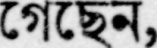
গেছেন,
